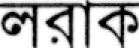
লরাক
